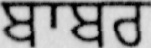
ਬਾਬਰ
